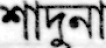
শাদুনা
